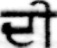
ਦੀ
